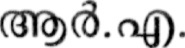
ആര്‍.എ.
